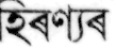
হিৰণ্যৰ
